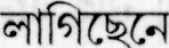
লাগিছেনে
